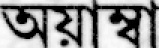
অয়াম্বা
